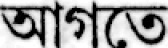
আগতে
